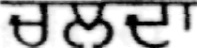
ਚਲਦਾ
